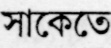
সাকেতে
